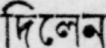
দিলেন
